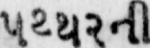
પથ્થરની
